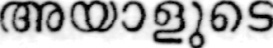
അയാളുടെ
